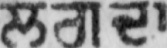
ਲਗਦਾ
